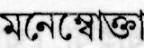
মনেম্বোক্তা
